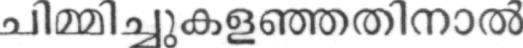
ചിമ്മിച്ചുകളഞ്ഞതിനാല്‍
